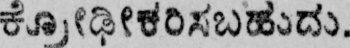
ಕ್ರೋಢೀಕರಿಸಬಹುದು.
